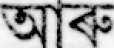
আৰু
